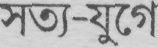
সত্য-যুগে
